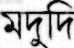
মদুদি
